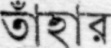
তাঁহার
